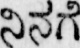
ನಿನಗೆ
